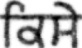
ਕਿਸੇ
